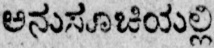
ಅನುಸೂಚಿಯಲ್ಲಿ
